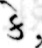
કે,
